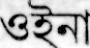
ওইনা
